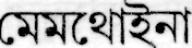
মেমথোইনা
